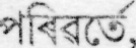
পৰিৱর্তে,
